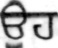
ਉਹ
